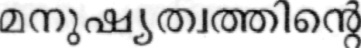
മനുഷ്യത്വത്തിന്റെ
